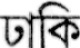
ঢাকি
